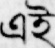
এই
